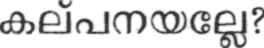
കല്പനയല്ലേ?
